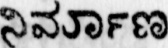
ನಿರ್ಮಾಣ
